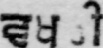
ਵਖਰੀ
